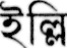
ইল্লি
